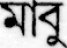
মাবু
